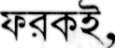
ফরকই,
